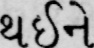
થઈને
